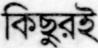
কিছুরই
